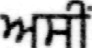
ਅਸੀਂ
